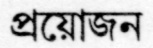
প্রয়োজন
